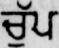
ਚੁੱਪ
